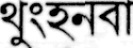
থুংহনবা
